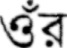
ওঁর
